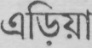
এড়িয়া
